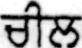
ਚੀਲ
